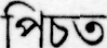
পিচত
